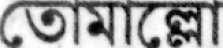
তোমাল্লো
